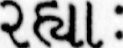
રહ્યાઃ
